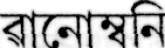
ৱানোম্বনি
